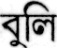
বুলি
